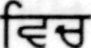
ਵਿਚ
